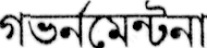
গভর্নমেন্টনা
